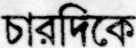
চারদিকে
